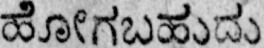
ಹೋಗಬಹುದು
